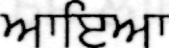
ਆਇਆ
